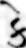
કે
